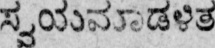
ಸ್ವಯಮಾಡಳಿತ
